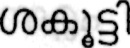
ശകൂട്ടി
